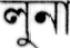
লুনা
